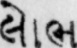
લોભ
